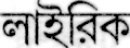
লাইরিক
